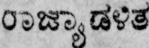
ರಾಜ್ಯಾಡಳಿತ
